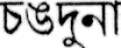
চঙদুনা
